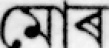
মোৰ
